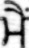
ਮੈਂ
